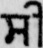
ਸੀ
